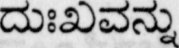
ದುಃಖವನ್ನು
